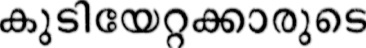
കുടിയേറ്റക്കാരുടെ
